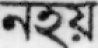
নহয়
